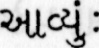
આવ્યું:
